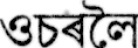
ওচৰলৈ
